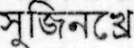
সুজিনখ্রে
